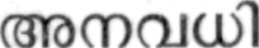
അനവധി
